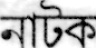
নাটক
